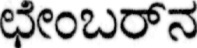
ಛೇಂಬರ್‌ನ
